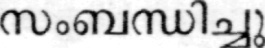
സംബന്ധിച്ചു
